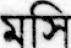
মসি
